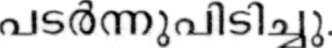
പടര്‍ന്നുപിടിച്ചു.
